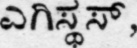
ಎಗಿಸ್ಥಸ್,
